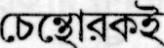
চেন্থোরকই
